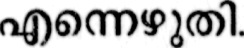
എന്നെഴുതി.
